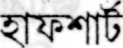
হাফশার্ট
